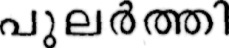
പുലര്‍ത്തി
